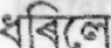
ধৰিলে
